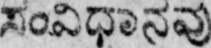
ಸಂವಿಧಾನವು
